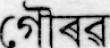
গৌৰৱ
